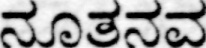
ನೂತನವ
